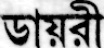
ডায়রী
